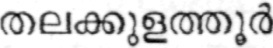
തലക്കുളത്തൂര്‍
